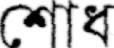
শোধ
